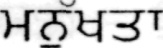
ਮਨੁੱਖਤਾ
